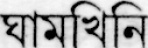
ঘামখিনি
